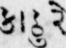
કાઠુરે
